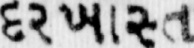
દરખાસ્ત
